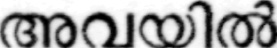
അവയില്‍
